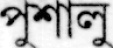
পুশালু
